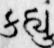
કહ્યું
